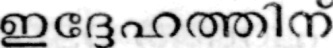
ഇദ്ദേഹത്തിന്
